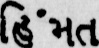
હિંમત
